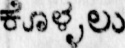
ಕೊಳ್ಳಲು
